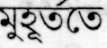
মুহূর্ততে
